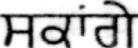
ਸਕਾਂਗੇ
